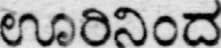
ಊರಿನಿಂದ
